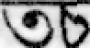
তচ
